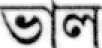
ভাল
